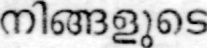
നിങ്ങളുടെ
